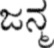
ಜನ್ಮ
